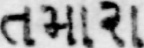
તમારા
